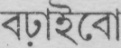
বঢ়াইবো
